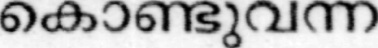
കൊണ്ടുവന്ന
